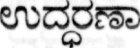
ಉದ್ಧರಣಾ
